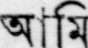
আমি
